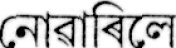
নোৱাৰিলে
